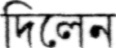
দিলেন
